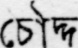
চৌদ্দ
